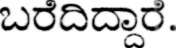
ಬರೆದಿದ್ದಾರೆ.
